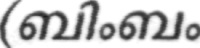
(ബിംബം
